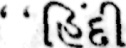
"હિંદી
